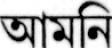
আমনি
